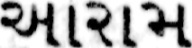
આરામ
